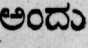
ಅಂದು
